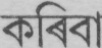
কৰিবা
